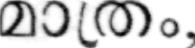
മാത്രം,
